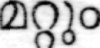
മറ്റും
